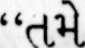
"તમે
